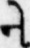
ને
